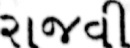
રાજવી
